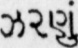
ઝરણું
